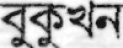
বুকুখন
